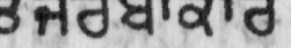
ਤਜਰਬਾਕਾਰ
